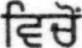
ਵਿਚੋਂ
